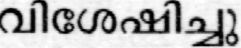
വിശേഷിച്ചു
